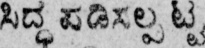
ಸಿದ್ಧಪಡಿಸಲ್ಪಟ್ಟ
